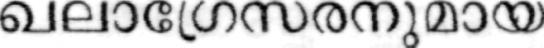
ഖലാഗ്രേസരനുമായ
